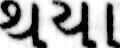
થયા
